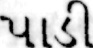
પાડી
